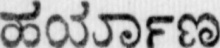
ಹರ್ಯಾಣ
